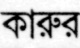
কারুর
